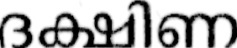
ദക്ഷിണ
